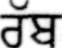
ਰੱਬ
